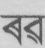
ৰৱ
